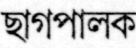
ছাগপালক
